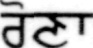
ਰੋਣਾ
